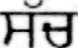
ਸੱਚ
